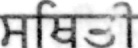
ਸਥਿਤੀ
